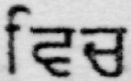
ਵਿਚ
